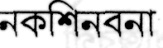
নকশিনবনা
